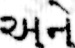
અને
